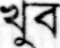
খুব
